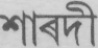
শাৰদী
